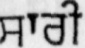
ਸਾਰੀ
